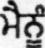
ਮੈਨੂੰ
